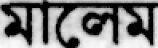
মালেম
